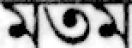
মতম
